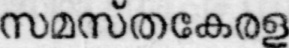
സമസ്തകേരള
